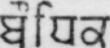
ਬੌਧਿਕ
